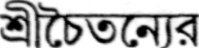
শ্রীচৈতন্যের
